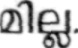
മില്ല.
